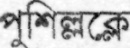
পুশিল্লক্লে
